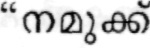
“നമുക്ക്
